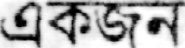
একজন
